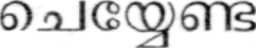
ചെയ്യേണ്ട
